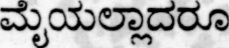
ಮೈಯಲ್ಲಾದರೂ
